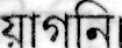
য়াগনি।
